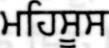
ਮਹਿਸੂਸ
